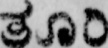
ತೂರಿ
